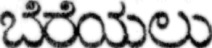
ಬೆರೆಯಲು
